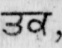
ਤਕ,
